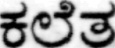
ಕಲೆತ
